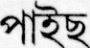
পাইছ
